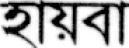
হায়বা
